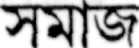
সমাজ
